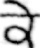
ਕੇ
